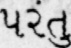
પરંતુ
